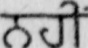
ਨਹੀਂ
